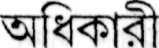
অধিকারী
